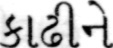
કાઢીને
